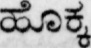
ಹೊಕ್ಕ
